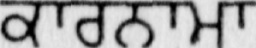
ਕਾਰਨਾਮਾ
